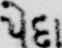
પેદા
